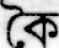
কৈ
